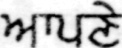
ਆਪਣੇ
